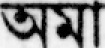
অমা
